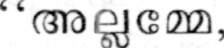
"അല്ലമ്മേ,
